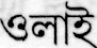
ওলাই
